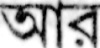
আর
